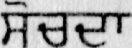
ਸੋਚਦਾ
